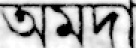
অমদা
